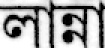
লান্না
